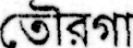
তৌরগা
